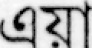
এয়া
